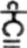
ਨੂੰ
